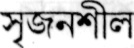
সৃজনশীল
